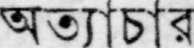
অত্যাচার
